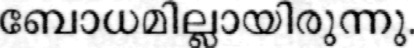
ബോധമില്ലായിരുന്നു.
